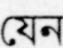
যেন
